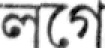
লগে
